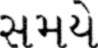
સમયે
